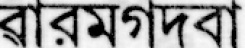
ৱারমগদবা
